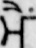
ਮੈਂ
